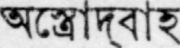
অস্ত্রোদ্‌বাহ
